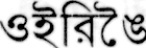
ওইরিঙৈ
